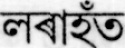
লৰাহঁত
